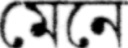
মেনে
